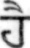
ਹੈ
